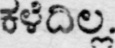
ಕಳೆದಿಲ್ಲ.
